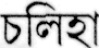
চলিহা
